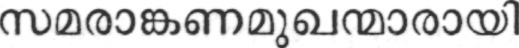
സമരാങ്കണമുഖന്മാരായി
